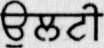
ਉਲਟੀ
